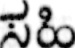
ಸಹಿ
